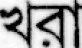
খরা
